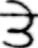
ਤੇ
